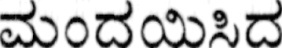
ಮಂದಯಿಸಿದ
